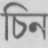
চিন
